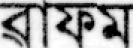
ৱাফম
